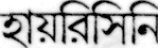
হায়রিসিনি
